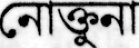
নোক্তুনা
